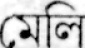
মেলি
